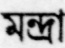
মন্দ্রা
